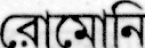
রোমোনি
